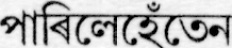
পাৰিলেহেঁতেন
